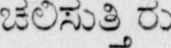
ಚಲಿಸುತ್ತಿರು
